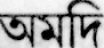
অমদি
